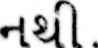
નથી.
